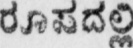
ರೂಪದಲ್ಲಿ
